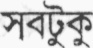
সবটুকু
